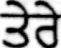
ਤੇਰੇ
